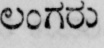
ಲಂಗರು
